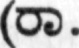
(ರಾ.
